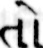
તો
